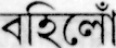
বহিলোঁ
